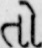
તો
